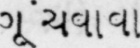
ગૂંચવાવા
